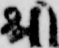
શ્રી
